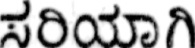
ಸರಿಯಾಗಿ
